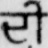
ਦੀ
